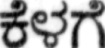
ಕೆಳಗೆ
